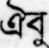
ঐবু
